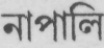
নাপালি
